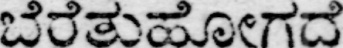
ಬೆರೆತುಹೋಗದೆ
